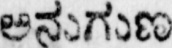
ಅನುಗುಣ
